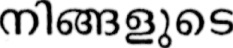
നിങ്ങളുടെ
